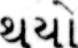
થયો
